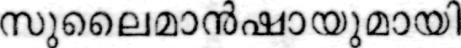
സുലൈമാന്‍ഷായുമായി
